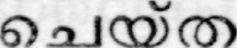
ചെയ്ത
